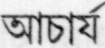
আচার্য
